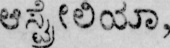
ಆಸ್ಟ್ರೇಲಿಯಾ,
